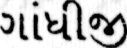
ગાંધીજી
